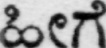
ಹೀಗೆ
